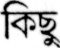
কিছু
